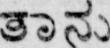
ತಾನು
